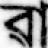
ৱা
